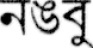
নঙবু
